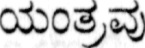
ಯಂತ್ರವು
